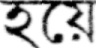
হয়ে
